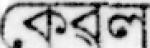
কেৱল
